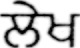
ਲੇਖ
